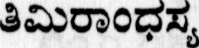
ತಿಮಿರಾಂಧಸ್ಯ
